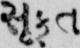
સૃકત
